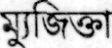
ম্যুজিক্তা
